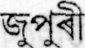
জুপুৰী
